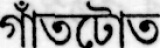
গাঁতটোত
